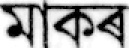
মাকৰ
